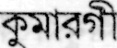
কুমারগী
